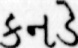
કનડે
